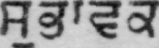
ਸੁਭਾਵਕ
